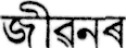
জীৱনৰ
